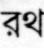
রথ
